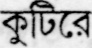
কুটিরে
